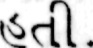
હતી.
